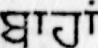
ਬਾਹਾਂ
